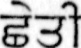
ਛੇਤੀ
